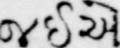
જઈએ
